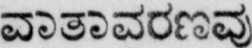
ವಾತಾವರಣವು
